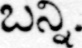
ಬನ್ನಿ.
